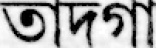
তাদগা
